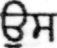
ਉਸ
